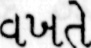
વખતે
